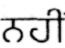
ਨਹੀਂ
